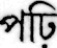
পঢ়ি
